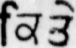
ਕਿਤੇ
